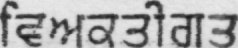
ਵਿਅਕਤੀਗਤ
